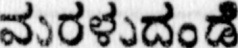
ಮರಳುದಂಡೆ
